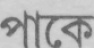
পাকে
